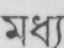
মধ্য
